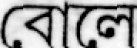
বোলে
